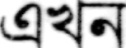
এখন
